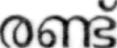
രണ്ട്
